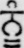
ਨੂੰ
